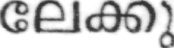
ലേക്കു
